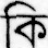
কি
